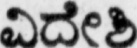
ವಿದೇಶಿ
